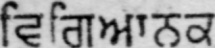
ਵਿਗਿਆਨਕ
